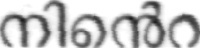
നിന്റെ
